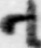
ન
